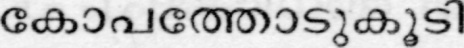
കോപത്തോടുകൂടി
